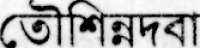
তৌশিন্নদবা
